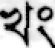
খং
